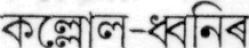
কল্লোল-ধ্বনিৰ
